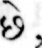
છે,
